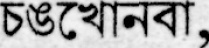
চঙখোনবা,
